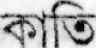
কাতি
